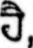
ਹੈ,
